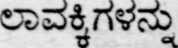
ಲಾವಕ್ಕಿಗಳನ್ನು
